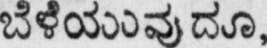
ಬೆಳೆಯುವುದೂ,
